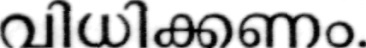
വിധിക്കണം.
